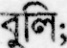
বুলি;
